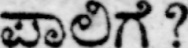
ಪಾಲಿಗೆ?
